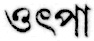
ওংপা
